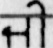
ਜੀ
